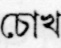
চোখ
